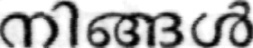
നിങ്ങള്‍
